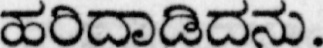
ಹರಿದಾಡಿದನು.
